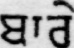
ਬਾਰੇ
